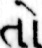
તો
